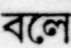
বলে
